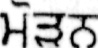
ਮੋੜਨ
